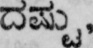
ದಷ್ಟು,
